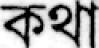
কথা
